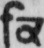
ਕਿ
